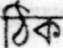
ঠিক
